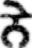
ਨੇ
